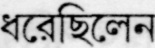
ধরেছিলেন
